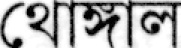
থোঙ্গাল
